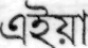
এইয়া
